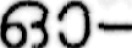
ഓ-
